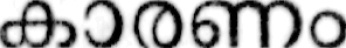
കാരണം
